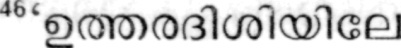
46'ഉത്തരദിശിയിലേ
